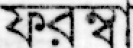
ফরম্বা
